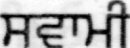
ਸਵਾਮੀ
